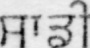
ਸਾਡੀ
